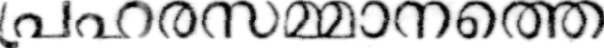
പ്രഹരസമ്മാനത്തെ
